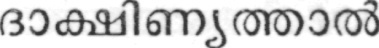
ദാക്ഷിണ്യത്താല്‍
